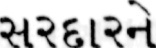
સરદારને
